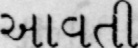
આવતી
